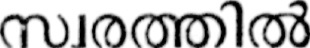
സ്വരത്തില്‍
